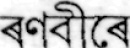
ৰণবীৰে
